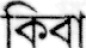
কিবা
